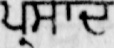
ਪ੍ਰਸਾਦ
